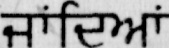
ਜਾਂਦਿਆਂ
